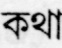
কথা
